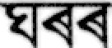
ঘৰৰ
